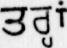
ਤਰ੍ਹਾਂ
